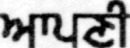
ਆਪਣੀ
